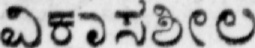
ವಿಕಾಸಶೀಲ
